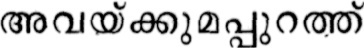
അവയ്ക്കുമപ്പുറത്ത്
